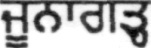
ਜੂਨਾਗੜ੍ਹ
